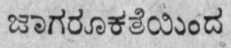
ಜಾಗರೂಕತೆಯಿಂದ
